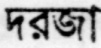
দরজা
